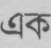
এক
